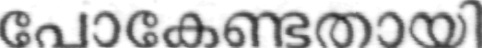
പോകേണ്ടതായി
